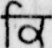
ਕਿ
